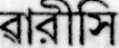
ৱারীসি
